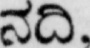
ನದಿ,
